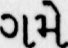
ગમે
